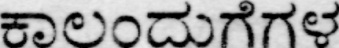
ಕಾಲಂದುಗೆಗಳ
